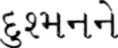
દુશ્મનને
